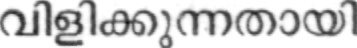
വിളിക്കുന്നതായി
